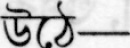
উঠে-
